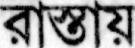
রাস্তায়
